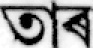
তাৰ
